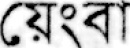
য়েংবা
